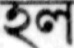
হল
